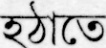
হঠাতে
